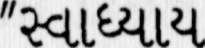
"સ્વાધ્યાય
